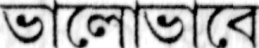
ভালোভাবে
